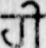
ਹੀ
